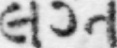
લગ્ન
